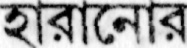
হারানোর
